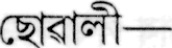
ছোৱালী-
